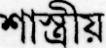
শাস্ত্ৰীয়
